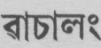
ৱাচালং
